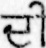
ਦੀ
